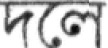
দলে
